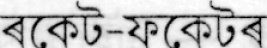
ৰকেট-ফকেটৰ
